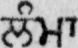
ਲੰਮਾ
